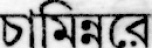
চামিন্নরে
